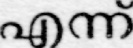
എന്ന്
